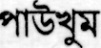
পাউখুম
